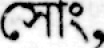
সোং,
